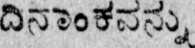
ದಿನಾಂಕವನ್ನು
